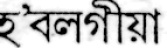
হ'বলগীয়া
